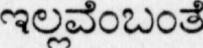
ಇಲ್ಲವೆಂಬಂತೆ
